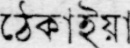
ঠেকাইয়া
